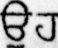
ਉਹ
